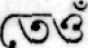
তেওঁ
